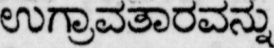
ಉಗ್ರಾವತಾರವನ್ನು
